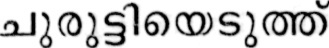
ചുരുട്ടിയെടുത്ത്
